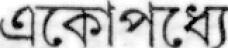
একোপধ্যে
